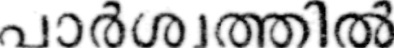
പാര്‍ശ്വത്തില്‍
